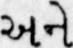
અને
